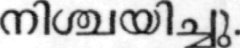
നിശ്ചയിച്ചു.
